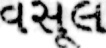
વસૂલ
